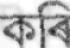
কৰি
